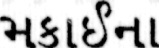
મકાઈના
